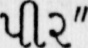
પીર"
